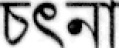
চৎনা
